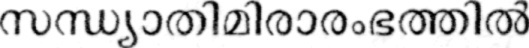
സന്ധ്യാതിമിരാരംഭത്തില്‍
